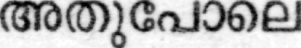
അതുപോലെ
